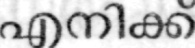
എനിക്ക്
